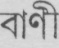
বাণী
